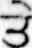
ਤੇ
